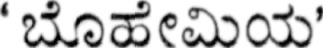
'ಬೊಹೇಮಿಯ'
